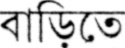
বাড়িতে
